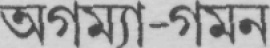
অগম্যা-গমন
